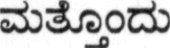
ಮತ್ತೊಂದು
